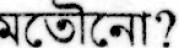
মতৌনো?
